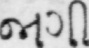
જાગી
